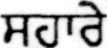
ਸਹਾਰੇ
